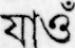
যাওঁ
